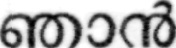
ഞാന്‍
